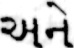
અને
